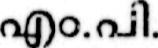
എം.പി.
